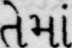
તેમાં
